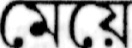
মেয়ে
